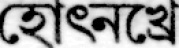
হোৎনখ্রে
